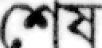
শেষ
